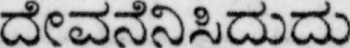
ದೇವನೆನಿಸಿದುದು
